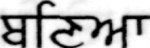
ਬਣਿਆ
